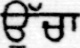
ਉੱਚਾ
